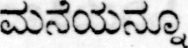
ಮನೆಯನ್ನೂ
